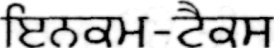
ਇਨਕਮ-ਟੈਕਸ
